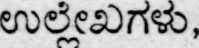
ಉಲ್ಲೇಖಗಳು,
